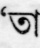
‘তা
